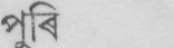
পুৰি
